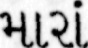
મારાં
